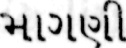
માગણી
